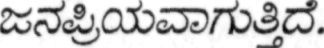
ಜನಪ್ರಿಯವಾಗುತ್ತಿದೆ.
